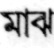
মাঝ
